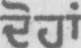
ਦੋਹਾਂ
